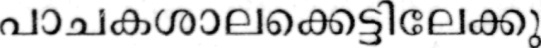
പാചകശാലക്കെട്ടിലേക്കു
